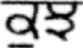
ਕੁਝ
